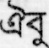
ঐবু
